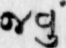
જવું
